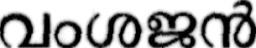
വംശജന്‍
